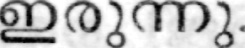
ഇരുന്നു.
